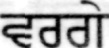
ਵਰਗੇ
